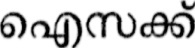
ഐസക്ക്
